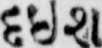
દઈશ
